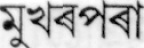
মুখৰপৰা
